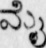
ಮೈ
